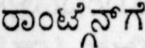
ರಾಂಟ್ಗೆನ್‌ಗೆ
